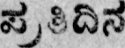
ಪ್ರತಿದಿನ
